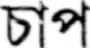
চাপ
